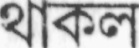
থাকল
